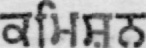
ਕਮਿਸ਼ਨ
